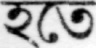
হতে
